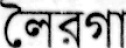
লৈরগা
